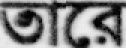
তারে
